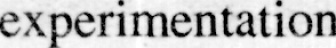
experimentation
